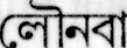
লৌনবা
